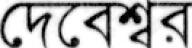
দেবেশ্বর
